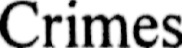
Crimes
